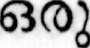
ഒരു
